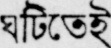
ঘটিতেই
